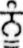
ਨੂੰ
